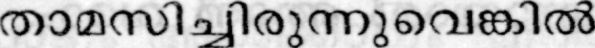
താമസിച്ചിരുന്നുവെങ്കില്‍
